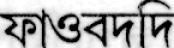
ফাওবদদি
